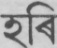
হৰি
